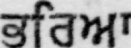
ਭਰਿਆ
